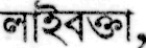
লাইবক্তা,
